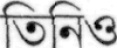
তিনিও
